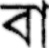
বা
